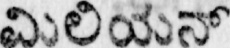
ಮಿಲಿಯನ್
